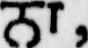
ਨਾ,
